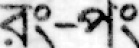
রং-পং
